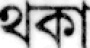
থকা
